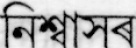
নিশ্বাসৰ
